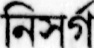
নিসর্গ
